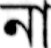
না
